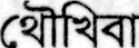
থৌখিবা
